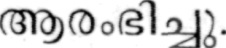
ആരംഭിച്ചു.
